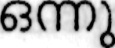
ഒന്നു
